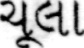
ચૂલા
